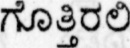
ಗೊತ್ತಿರಲಿ
